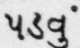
પડવું
